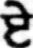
ਏ
